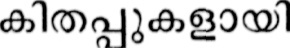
കിതപ്പുകളായി
